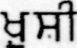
ਖ਼ੁਸ਼ੀ
